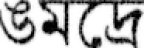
ঙমদ্রে
